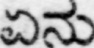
ಏನು
